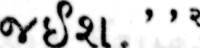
જઈશ."૨
